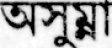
অসুম্না
